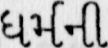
ધર્મની
